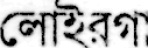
লোইরগা
